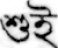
শুই
